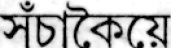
সঁচাকৈয়ে
